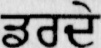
ਡਰਦੇ
